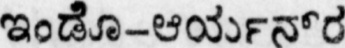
ಇಂಡೊ-ಆರ್ಯನ್ರ
